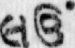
લઉં
